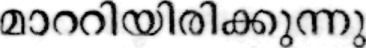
മാററിയിരിക്കുന്നു
